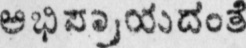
ಅಭಿಪ್ರಾಯದಂತೆ
